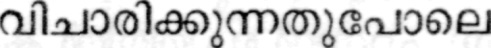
വിചാരിക്കുന്നതുപോലെ
